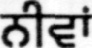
ਨੀਵਾਂ
